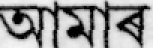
আমাৰ
